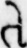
તે
